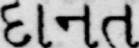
દાનત
